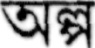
অল্প
